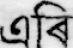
এৰি
